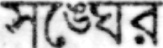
সঙ্ঘের
